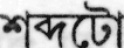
শব্দটো
